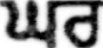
ਘਰ
